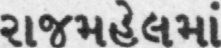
રાજમહેલમાં
